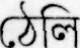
ঠেলি
